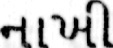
નાખી
